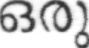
ഒരു
